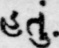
હતું.
